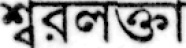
শ্বরলক্তা
